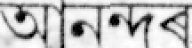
আনন্দৰ
